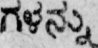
ಗಳನ್ನು
